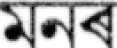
মনৰ
